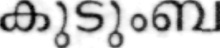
കുടുംബ
